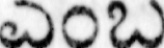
ಎಂಬ
